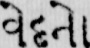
વેદનો
